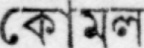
কোমল
